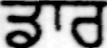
ਡਾਰ
